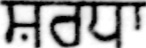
ਸ਼ਰਧਾ
